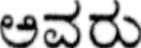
ಅವರು
